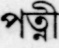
পত্নী
